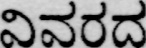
ವಿವರದ
